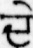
ਦੇ
